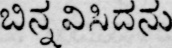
ಬಿನ್ನವಿಸಿದನು
